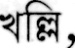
খল্লি,
